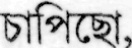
চাপিছো,
